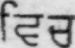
ਵਿਚ
